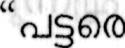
"പട്ടരെ
